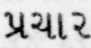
પ્રચાર
